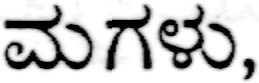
ಮಗಳು,
